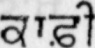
ਕਾਫ਼ੀ
